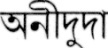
অনীদুদা
